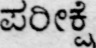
ಪರೀಕ್ಷೆ
